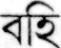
বহি
